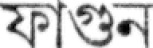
ফাগুন
